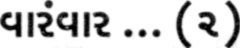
વારંવાર.......(૨)
